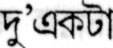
দু'একটা
